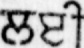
ਲਈ
